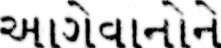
આગેવાનોને
